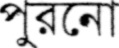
পুরনো
